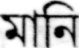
মানি
